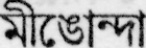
মীঙোন্দা
